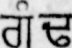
ਗੰਢ
